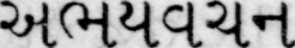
અભયવચન
